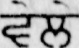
ਵੇਲੇ
